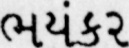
ભયંકર
